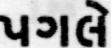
પગલે
